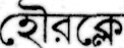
হৌরক্লে
